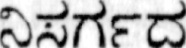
ನಿಸರ್ಗದ
